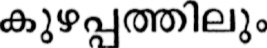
കുഴപ്പത്തിലും
